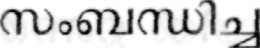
സംബന്ധിച്ച
